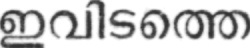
ഇവിടത്തെ
